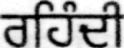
ਰਹਿੰਦੀ
